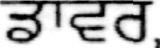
ਡਾਵਰ,
